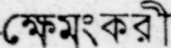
ক্ষেমংকরী
